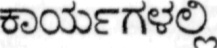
ಕಾರ್ಯಗಳಲ್ಲಿ
